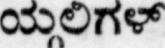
ಯ್ಗಲಿಗಳ್
